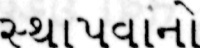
સ્થાપવાનો
